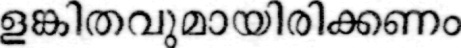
ളങ്കിതവുമായിരിക്കണം
